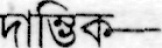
দাম্ভিক-
